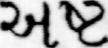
અષ્ટ
